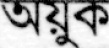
অয়ুক
